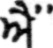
ਐ''
